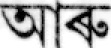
আৰু
